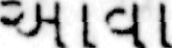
આવા
